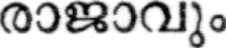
രാജാവും
